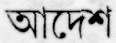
আদেশ
